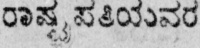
ರಾಷ್ಟ್ರಪತಿಯವರ
